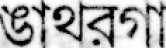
ঙাথরগা
